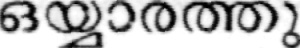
ഒയ്യാരത്തു
